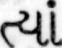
ત્યાં
